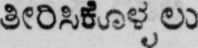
ತೀರಿಸಿಕೊಳ್ಳಲು
